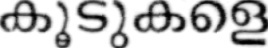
കൂടുകളെ
